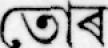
তোৰ
